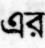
এর
